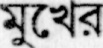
মুখের
